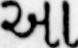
આ
